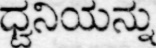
ಧ್ವನಿಯನ್ನು
